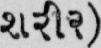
શરીર)
